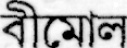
বীমোল
